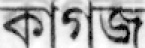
কাগজ
